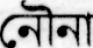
নৌনা
